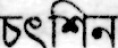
চৎশিন
